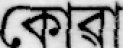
কোৱা
